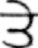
ਤੇ
